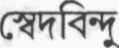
স্বেদবিন্দু
